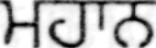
ਮਹਾਨ
